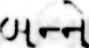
બન્ને
